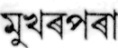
মুখৰপৰা
